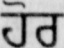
ਹੋਰ
